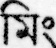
মিং
